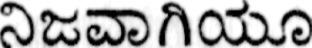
ನಿಜವಾಗಿಯೂ
